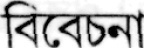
বিবেচনা
